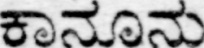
ಕಾನೂನು
